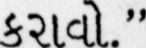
કરાવો."
